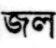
জল
